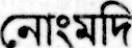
নোংমদি
